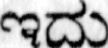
ಇದು
